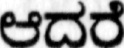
ಆದರೆ
